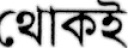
থোকই
